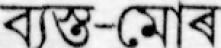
ব্যস্ত-মোৰ
